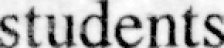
studentws
